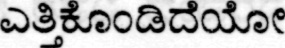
ಎತ್ತಿಕೊಂಡಿದೆಯೋ
